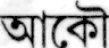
আকৌ
